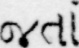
જતાં
